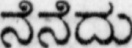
ನೆನೆದು
